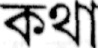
কথা
